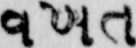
વખત
